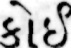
કોઈ
